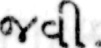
જવી.
